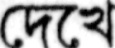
দেখে
